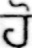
ਹੋ
